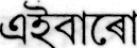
এইবাৰো
